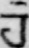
ਹੋ
